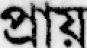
প্রায়
